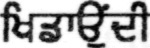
ਖਿਡਾਉਂਦੀ
